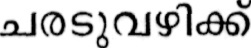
ചരടുവഴിക്ക്
